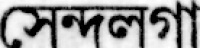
সেন্দলগা
